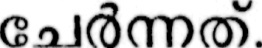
ചേര്‍ന്നത്.
